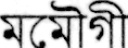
মমৌগী
